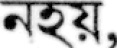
নহয়,
